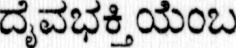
ದೈವಭಕ್ತಿಯೆಂಬ
